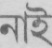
নাই
